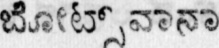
ಬೋಟ್ಸ್‌ವಾನಾ
